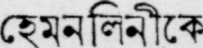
হেমনলিনীকে
